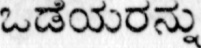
ಒಡೆಯರನ್ನು
